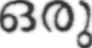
ഒരു
